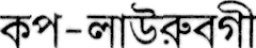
কপ-লাউরুবগী
